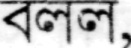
বলল,
